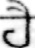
ਹੈ
